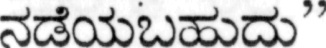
ನಡೆಯಬಹುದು’’
